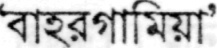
‘বাহরগামিয়া’
